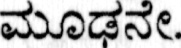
ಮೂಢನೇ.
